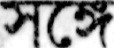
সঙ্গে
